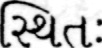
સ્થિતઃ
